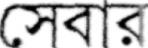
সেবার
